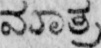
ಮಾತ್ರ
